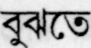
বুঝতে
